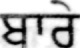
ਬਾਰੇ
